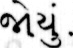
જેયું
